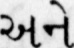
અને
